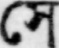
সে
